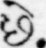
છે.
